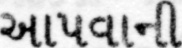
આપવાની
